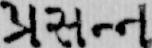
પ્રસન્ન
